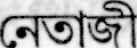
নেতাজী
